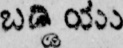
ಬಡ್ಡಿಯು
